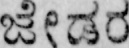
ಜೇಡರ
